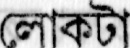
লোকটা
